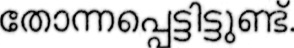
തോന്നപ്പെട്ടിട്ടുണ്ട്.
